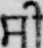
ਸੀ
